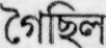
গৈছিল
